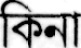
কিনা
